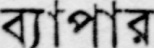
ব্যাপার
